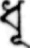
ধূ
